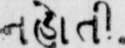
નહોતી.
